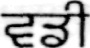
ਵਡੀ
